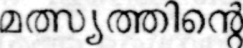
മത്സ്യത്തിന്റെ
